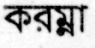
করম্না
